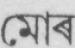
মোৰ
